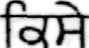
ਕਿਸੇ
